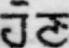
ਹੋਣ
